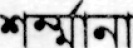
শর্ম্মানা
